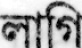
লাগি
